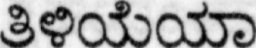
ತಿಳಿಯೆಯಾ
